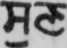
ਸੁਣ
